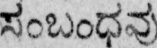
ಸಂಬಂಧವು
